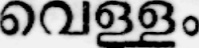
വെള്ളം
